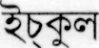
ইচ্‌কুল
